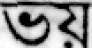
ভয়
